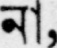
না,
